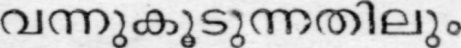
വന്നുകൂടുന്നതിലും
